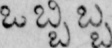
ಒಬ್ಬಿಬ್ಬ
